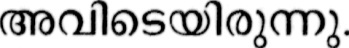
അവിടെയിരുന്നു.
